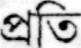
প্রতি
